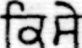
ਕਿਸੇ
